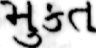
મુક્ત
